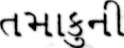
તમાકુની
